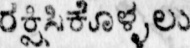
ರಕ್ಷಿಸಿಕೊಳ್ಳಲು
